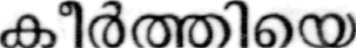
കീര്‍ത്തിയെ
